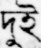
দুই
